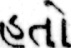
હતો
